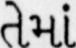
તેમાં
